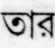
তার
